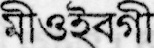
মীওইবগী
